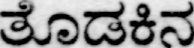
ತೊಡಕಿನ
